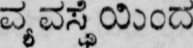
ವ್ಯವಸ್ಥೆಯಿಂದ
